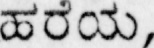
ಹರೆಯ,
